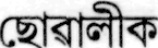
ছোৱালীক
